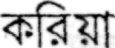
করিয়া
